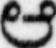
ಆ
